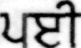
ਪਈ
